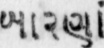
બારણાં
